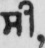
ਸੀ,
